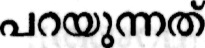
പറയുന്നത്
